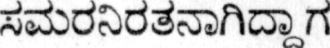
ಸಮರನಿರತನಾಗಿದ್ದಾಗ
